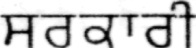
ਸਰਕਾਰੀ
